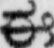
ಈ
